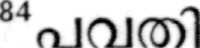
84പവതി
